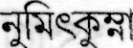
নুমিৎকুম্না
